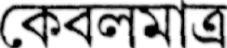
কেবলমাত্র
